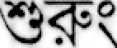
শুরুং
